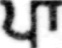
ਪਾ
